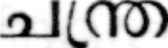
ചന്ത്ര
